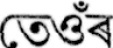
তেওঁৰ
